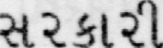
સરકારી
